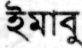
ইমাবু
